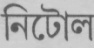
নিটোল
